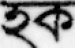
হক
